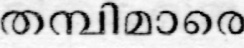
തമ്പിമാരെ
